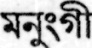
মনুংগী
